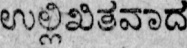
ಉಲ್ಲಿಖಿತವಾದ
